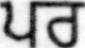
ਪਰ
